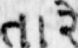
તારે
